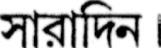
সারাদিন।
